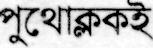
পুথোক্লকই
